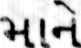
માને
